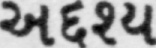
અદ્દશ્ય
